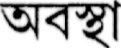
অবস্থা
